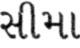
સીમા
